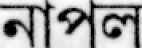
নাপল
